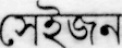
সেইজন
